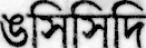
ঙসিসিদি
